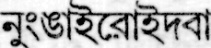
নুংঙাইরোইদবা
